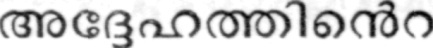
അദ്ദേഹത്തിന്റെ
